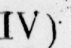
IV)
